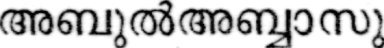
അബുല്‍അബ്ബാസു
